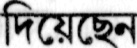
দিয়েছেন
